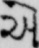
એ
